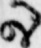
જે
